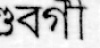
শুবগী
